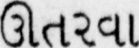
ઊતરવા
